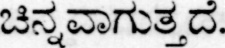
ಚಿನ್ನವಾಗುತ್ತದೆ.
